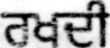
ਰਖਦੀ
